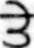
ਤੇ
